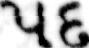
પદ
